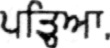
ਪੜ੍ਹਿਆ,
